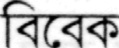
বিবেক
